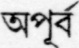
অপূর্ব
